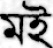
মই
